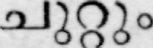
ചുറ്റും
